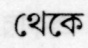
থেকে
